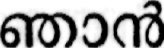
ഞാന്‍
